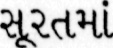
સૂરતમાં
